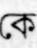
কে
